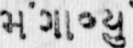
મંગાવ્યું
